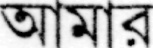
আমার
